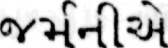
જર્મનીએ
